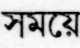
সময়ে
